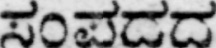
ಸಂಪದದ
